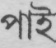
পাই
